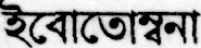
ইবোতোম্বনা
